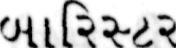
બારિસ્ટર
